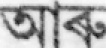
আৰু
